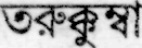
তরুক্কুম্বা
